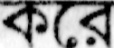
করে
